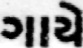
ગાયે
